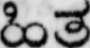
ಹಿತ
